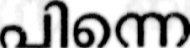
പിന്നെ
